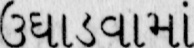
ઉઘાડવામાં
